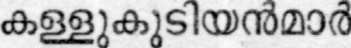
കള്ളുകുടിയന്‍മാര്‍
